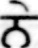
ਨੇ
